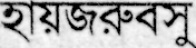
হায়জরুবসু
